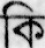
কি
